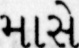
માસે
